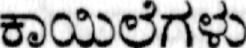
ಕಾಯಿಲೆಗಳು
